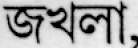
জখলা,
